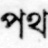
পথ
